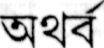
অথর্ব
